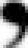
সিনা
